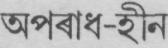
অপৰাধ-হীন
